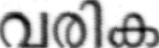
വരിക
